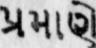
પ્રમાણે
